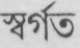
স্বৰ্গত
